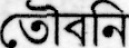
তৌবনি
